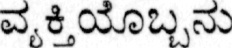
ವ್ಯಕ್ತಿಯೊಬ್ಬನು
